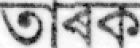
তাৰক
